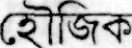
হৌজিক
